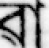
ৱা
